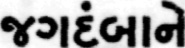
જગદંબાને
